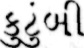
કુટુંબી
